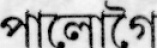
পালোগৈ
